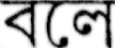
বলে
